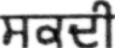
ਸਕਦੀ
